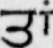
ਤਾਂ
